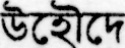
উহৌদে
